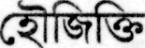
হৌজিক্তি
